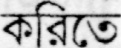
করিতে
